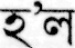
হ'ল
